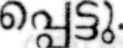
പ്പെട്ടു.
